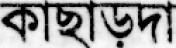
কাছাড়দা
